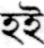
হই
